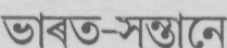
ভাৰত-সন্তানে
